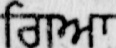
ਗਿਆ
